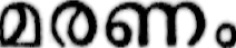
മരണം
